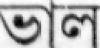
ভাল
